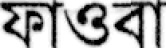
ফাওবা
